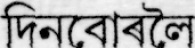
দিনবোৰলৈ
